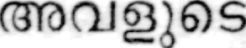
അവളുടെ
